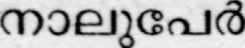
നാലുപേര്‍
